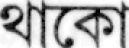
থাকো
